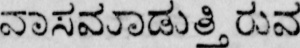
ವಾಸಮಾಡುತ್ತಿರುವ
